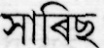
সাৰিছ
